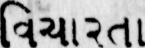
વિચારતા
